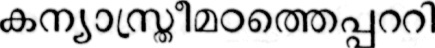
കന്യാസ്തീമംത്തെപ്പററി
